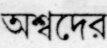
অশ্বদের
